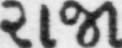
રાજા
